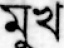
মুখ
